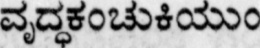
ವೃದ್ಧಕಂಚುಕಿಯುಂ
